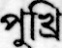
পুখ্রি
